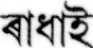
ৰাধাই
